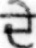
ਦੇ
